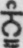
ਨੂੰ
